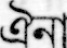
ঐনা
